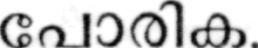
പോരിക.
